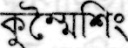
কুম্মৈশিং
